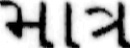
માત્ર
